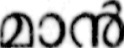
മാന്‍
